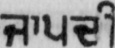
ਜਾਪਦੀ
